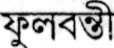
ফুলবন্তী
